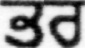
ਭਰ
